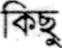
কিছু
